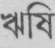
ঋষি
